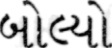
બોલ્યો
